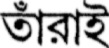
তাঁরাই
